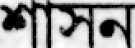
শাসন
